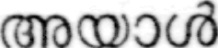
അയാള്‍
